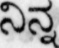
ನಿನ್ನ
